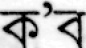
ক'ব
